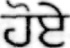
ਹੋਏ
